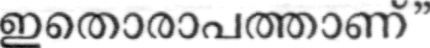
ഇതൊരാപത്താണ്”
